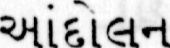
આંદોલન
